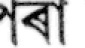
পৰা
